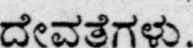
ದೇವತೆಗಳು.
